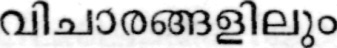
വിചാരങ്ങളിലും
